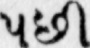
પછી
